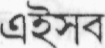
এইসব
